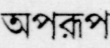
অপরূপ
